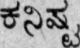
ಕನಿಷ್ಟ
